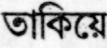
তাকিয়ে
